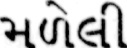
મળેલી
